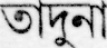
তাদুনা
